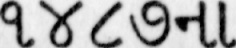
1487ના
